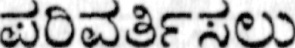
ಪರಿವರ್ತಿಸಲು
